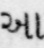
આ
